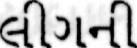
લીગની
